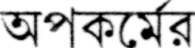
অপকর্মের
